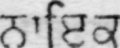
ਨਾਇਕ
